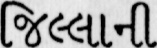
જિલ્લાની
